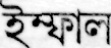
ইম্ফাল
